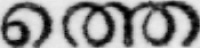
ത്തെ
